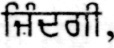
ਜ਼ਿੰਦਗੀ,
